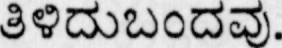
ತಿಳಿದುಬಂದವು.
